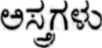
ಅಸ್ತ್ರಗಳು
